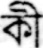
কী
